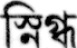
স্নিগ্ধ
